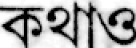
কথাও
